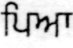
ਪਿਆ
